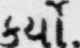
કર્યો.
